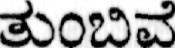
ತುಂಬಿವೆ
